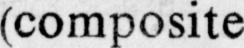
(composite
